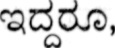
ಇದ್ದರೂ,
